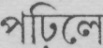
পঢ়িলে
